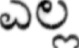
ಎಲ್ಲ
